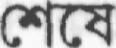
শেষে
